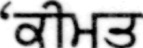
'ਕੀਮਤ
